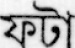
ফটা
